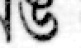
নঙ
